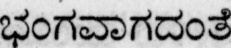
ಭಂಗವಾಗದಂತೆ
